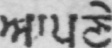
ਆਪਣੇ
